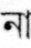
না
